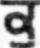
ਕੁ
